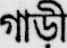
গাড়ী
